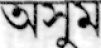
অসুম
